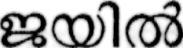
ജയില്‍
